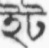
ইট
